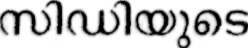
സിഡിയുടെ
